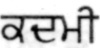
ਕਦਮੀ
